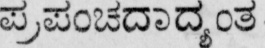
ಪ್ರಪಂಚದಾದ್ಯಂತ
